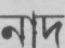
নাদ
